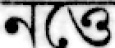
নত্তে
